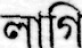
লাগি
